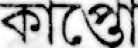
কাপ্তো
